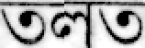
তলত
